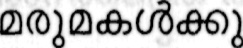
മരുമകള്‍ക്കു
